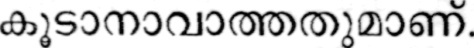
കൂടാനാവാത്തതുമാണ്.
